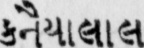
કનૈયાલાલ
